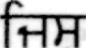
ਜਿਸ
